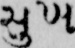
સુખ
